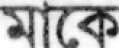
মাকে
